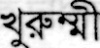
খুরুম্মী
